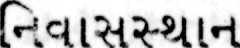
નિવાસસ્થાન
